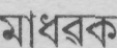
মাধৱক
